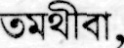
তমথীবা,
